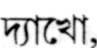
দ্যাখো,
